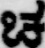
ಚ
